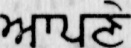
ਆਪਣੇ
